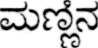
ಮಣ್ಣಿನ
